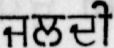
ਜਲਦੀ
